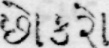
છોકરો
